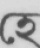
হে
